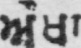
ਔਖਾ
